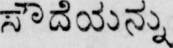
ಸೌದೆಯನ್ನು
